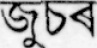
জুচৰ
